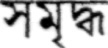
সমৃদ্ধ
